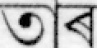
তাৰ
